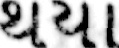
થયા
